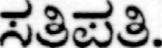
ಸತಿಪತಿ.
